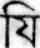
যি
